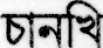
চানখি
